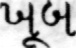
ખૂબ
